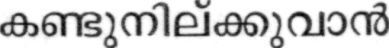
കണ്ടുനില്ക്കുവാന്‍
